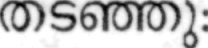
തടഞ്ഞു:
